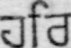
ਹਰਿ
